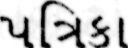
પત્રિકા
